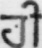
ਹੀ
